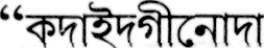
“কদাইদগীনোদা
